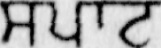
ਸਪਾਟ
